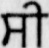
ਸੀ
